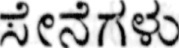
ಸೇನೆಗಳು
